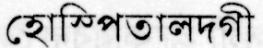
হোস্পিতালদগী
